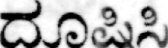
ದೂಷಿಸಿ
